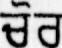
ਚੋਰ
